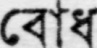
বোধ
